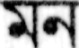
মন
